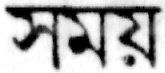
সময়
